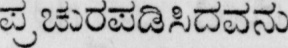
ಪ್ರಚುರಪಡಿಸಿದವನು
